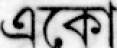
একো
